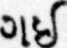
ગઈ
